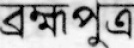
ব্রহ্মপুত্র
